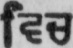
ਵਿਚ
